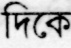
দিকে
